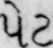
પેટ
